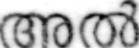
അല്‍
